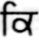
ਕਿ
